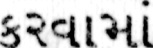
કરવામાં
